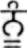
ਨੂੰ
